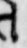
તે
